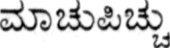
ಮಾಚುಪಿಚ್ಚು
